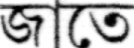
জাতে
